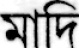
মাদি
